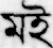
মই
